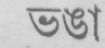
ভঙা
